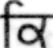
ਕਿ
